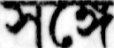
সঙ্গে
